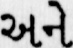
અને
